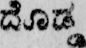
ದೊಡ್ಡ
